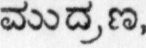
ಮುದ್ರಣ,
